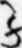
કે
